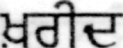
ਖ਼ਰੀਦ
